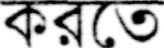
করতে
